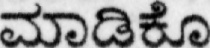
ಮಾಡಿಕೊ
